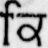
ਕਿ
